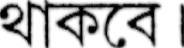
থাকবে।
